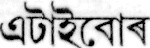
এটাইবোৰ
